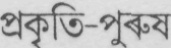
প্ৰকৃতি-পুৰুষ
